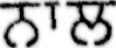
ਨਾਲ
